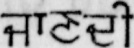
ਜਾਣਦੀ
